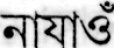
নাযাওঁ
